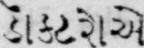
ડૉક્ટરોએ
